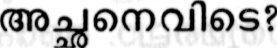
അച്ഛനെവിടെ?
